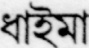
ধাইমা
